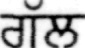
ਗੱਲ
